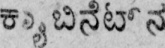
ಕ್ಯಾಬಿನೆಟ್‌ನ
